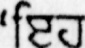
'ਇਹ
